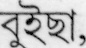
বুইছা,
